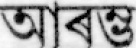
আৰম্ভ
